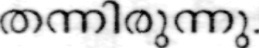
തന്നിരുന്നു.
